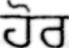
ਹੋਰ
